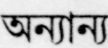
অন্যান্য
